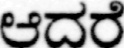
ಆದರೆ
